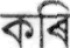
কৰি
